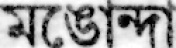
মঙোন্দা
